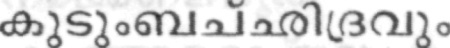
കുടുംബച്ഛിദ്രവും
